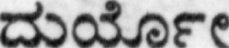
ದುರ್ಯೋ
